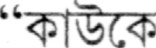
“কাউকে
